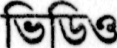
ভিডিও
